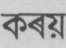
কৰয়
